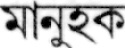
মানুহক
